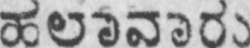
ಹಲಾವಾರು
